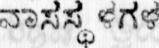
ವಾಸಸ್ಥಳಗಳ
